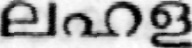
ലഹള
